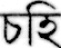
চহি
